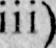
iii)
